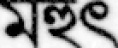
মহুৎ
